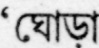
‘ঘোড়া
